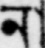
না
